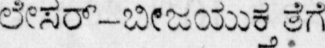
ಲೇಸರ್-ಬೀಜಯುಕ್ತತೆಗೆ
